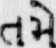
તમે
